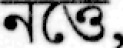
নত্তে,
